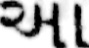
આ
